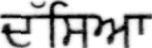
ਦੱਸਿਆ
